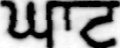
ਘਾਟ
